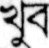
খুব
